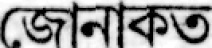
জোনাকত
